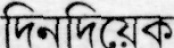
দিনদিয়েক
